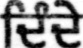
ਦਿੰਦੇ
